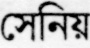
সেনিয়
